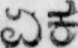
ಏಕ
